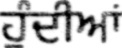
ਹੁੰਦੀਆਂ
